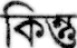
কিন্তু
